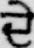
ਦੇ
